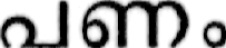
പണം
